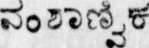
ವಂಶಾಣ್ವಿಕ
